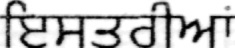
ਇਸਤਰੀਆਂ
